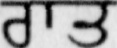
ਰਾਤ
